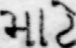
માટે
